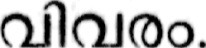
വിവരം.
